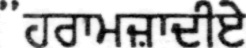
''ਹਰਾਮਜ਼ਾਦੀਏ
